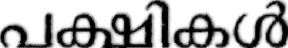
പക്ഷികള്‍
